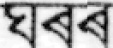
ঘৰৰ
